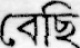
বেছি
